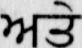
ਅਤੇ
